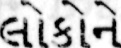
લોકોને
